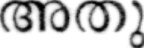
അതു
